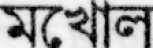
মখোল
